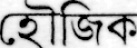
হৌজিক
